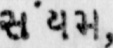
સંયમ,
